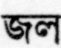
জল
